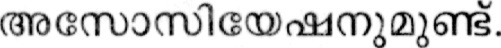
അസോസിയേഷനുമുണ്ട്.
